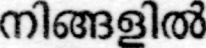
നിങ്ങളില്‍
